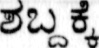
ಶಬ್ದಕ್ಕೆ
